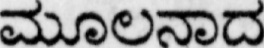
ಮೂಲನಾದ
